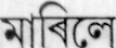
মাৰিলে
